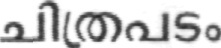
ചിത്രപടം
